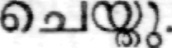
ചെയ്തു.
